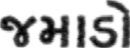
જમાડો
